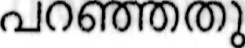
പറഞ്ഞതു
